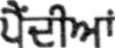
ਪੈਂਦੀਆਂ
